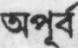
অপূর্ব
